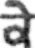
ਕੇ
